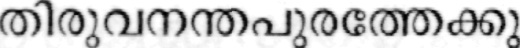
തിരുവനന്തപുരത്തേക്കു
